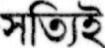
সত্যিই
